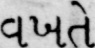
વખતે
